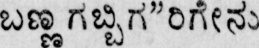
ಬಣ್ಣಗಬ್ಬಿಗ”ರಿಗೇನು
